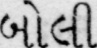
બોલી
